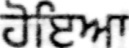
ਹੋਇਆ
